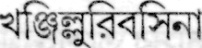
খঞ্জিল্লুরিবসিনা
